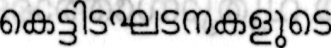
കെട്ടിടഘടനകളുടെ
